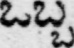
ಒಬ್ಬ
